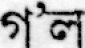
গ'ল
